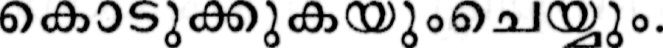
കൊടുക്കുകയുംചെയ്യും.
